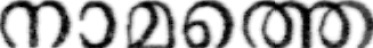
നാമത്തെ
